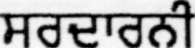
ਸਰਦਾਰਨੀ
